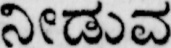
ನೀಡುವ
